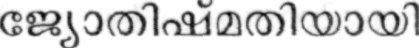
ജ്യോതിഷ്മതിയായി
